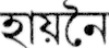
হায়নৈ
